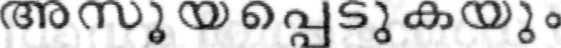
അസൂയപ്പെടുകയും
